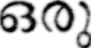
ഒരു
